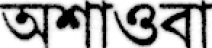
অশাওবা
